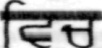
ਵਿਚ
